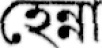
হেন্না
